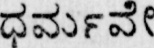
ಧರ್ಮವೇ
